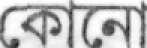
কোনো
